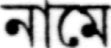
নামে
